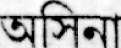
অসিনা
